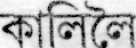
কালিলৈ
